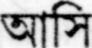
আসি
